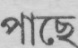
পাছে
